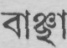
বাঞ্জা
